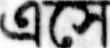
এসে
